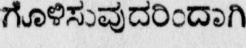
ಗೊಳಿಸುವುದರಿಂದಾಗಿ
